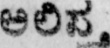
ಅಲಿಪ್ತ
